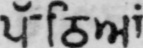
ਪੱਠਿਆਂ
